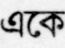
একে
